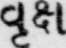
વૃક્ષ
